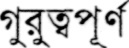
গুরুত্বপূর্ণ
